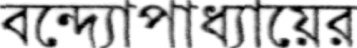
বন্দ্যোপাধ্যায়ের
